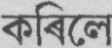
কৰিলে
